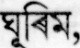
ঘূৰিম,
